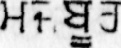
ਮਜਬੂਰ
